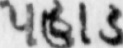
પહાડ
